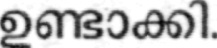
ഉണ്ടാക്കി.
